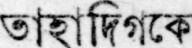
তাহাদিগকে
